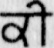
ਕੀ
